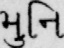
મુનિ
